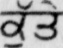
ਕੁੱਤੇ
